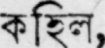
কহিল,
